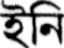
ইনি
